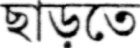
ছাড়তে
